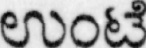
ಉಂಟೆ
